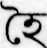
হৈ
